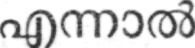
എന്നാല്‍
